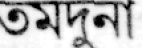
তমদুনা
